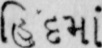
હિંદમાં
